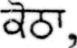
ਕੋਠਾ,
